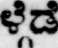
ಳ್ಗೆಡೆ
